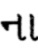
ના
